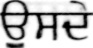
ਉਸਦੇ
